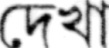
দেখা
